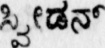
ಸ್ವೀಡನ್
